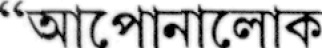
"আপোনালোক
